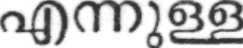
എന്നുള്ള
